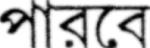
পারবে
